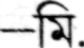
-মি.
